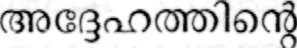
അദ്ദേഹത്തിന്റെ
